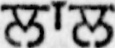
ਲਾਲ
